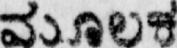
ಮೂಲಕ
